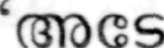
'അടേ
